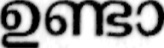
ഉണ്ടാ
